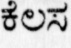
ಕೆಲಸ
